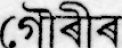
গৌৰীৰ
